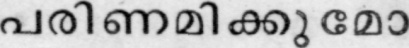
പരിണമിക്കുമോ
